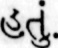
હતું.
